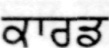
ਕਾਰਡ
